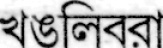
খঙলিবরা
